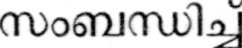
സംബന്ധിച്ച്
